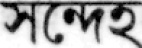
সন্দেহ
